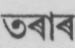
তৰাৰ
